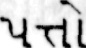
પત્તો
